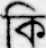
কি
